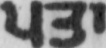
ਪਤਾ
